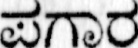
ಪಗಾರ
